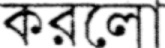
করলো
